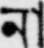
না
